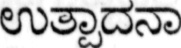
ಉತ್ಪಾದನಾ
